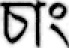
চাং
